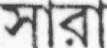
সারা
